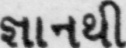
જ્ઞાનથી
